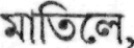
মাতিলে,
